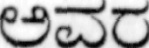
ಅವರ
